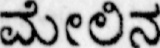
ಮೇಲಿನ
